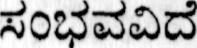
ಸಂಭವವಿದೆ
